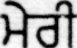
ਮੇਰੀ
